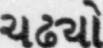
ચઢ્યો
